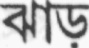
ঝাড়
